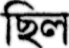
ছিল
